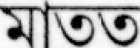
মাতত
